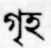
গৃহ
